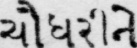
ચૌધરીને
